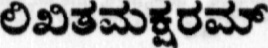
ಲಿಖಿತಮಕ್ಷರಮ್
